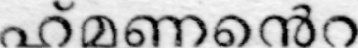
ഹ്മണന്റെ
